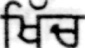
ਖਿੱਚ
